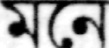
মনে
